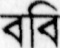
ববি
